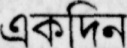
একদিন
